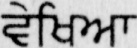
ਵੇਖਿਆ
